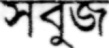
সবুজ
